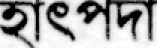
হাৎপদা
